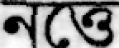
নত্তে
